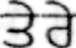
ਤੇਰੇ
